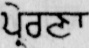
ਪ੍ਰੇਰਣਾ
